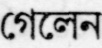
গেলেন
